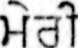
ਮੇਰੀ
